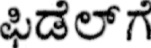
ಫಿಡೆಲ್ಗೆ
